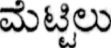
ಮೆಟ್ಟಿಲು
